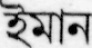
ইমান
